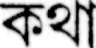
কথা
